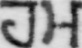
ਹਮ
